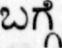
ಬಗ್ಗೆ
